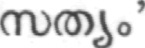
സത്യം’
